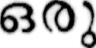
ഒരു
